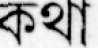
কথা
